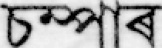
চম্পাৰ
